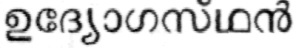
ഉദ്യോഗസ്ഥന്‍
